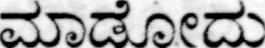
ಮಾಡೋದು
